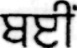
ਬਈਂ
